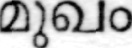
മുഖം
